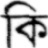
কি
